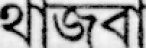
থাজবা
